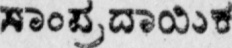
ಸಾಂಪ್ರದಾಯಿಕ
